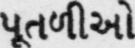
પૂતળીઓ
